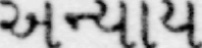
અન્યાય
